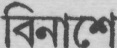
বিনাশে
